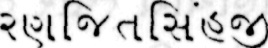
રણજિતસિંહજી
